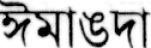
ঈমাঙদা
